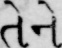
તેને
